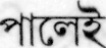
পালেই
